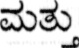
ಮತ್ತು
